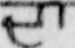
ਦਾ
